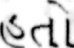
હતો
